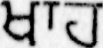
ਖਾਹ
